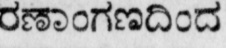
ರಣಾಂಗಣದಿಂದ
